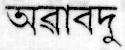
অৱাবদু
